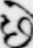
છે
